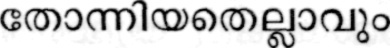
തോന്നിയതെല്ലാവും
